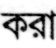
করা
